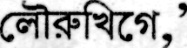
লৌরুখিগে,’
